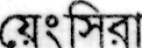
য়েংসিরা
